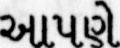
આપણે
